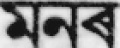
মনৰ
